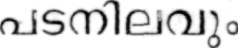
പടനിലവും
